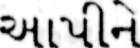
આપીને
